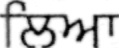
ਲਿਆ
